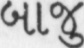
બાજુ
